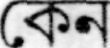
কেন
